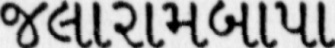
જલારામબાપા
